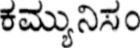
ಕಮ್ಯುನಿಸಂ
